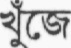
খুঁজে
